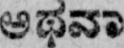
ಅಥವಾ
